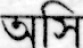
অসি
